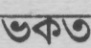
ভকত
